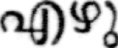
എഴു
